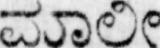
ಮಾಲೀ
